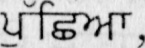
ਪੁੱਛਿਆ,
